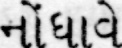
નોંધાવે
